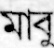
মাবু
